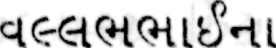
વલ્લભભાઈના
